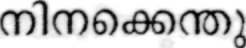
നിനക്കെന്തു
